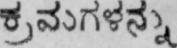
ಕ್ರಮಗಳನ್ನು
